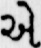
એ
